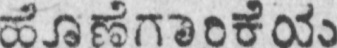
ಹೊಣೆಗಾರಿಕೆಯ
